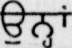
ਉਨ੍ਹਾਂ
